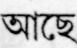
আছে
